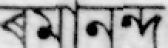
ৰমানন্দ
